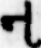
ન
